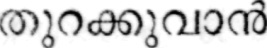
തുറക്കുവാന്‍
